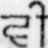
ਵੀ
